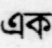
এক
